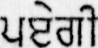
ਪਏਗੀ
